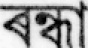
ৰন্ধা
